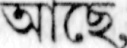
আছে,
